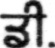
ਡੀ.
